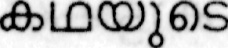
കഥയുടെ
